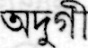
অদুগী
